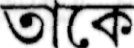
তাকে
